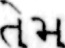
તેમ
